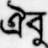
ঐবু
